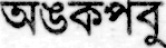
অঙকপবু
